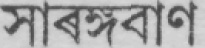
সাৰঙ্গবাণ
